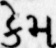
કેમ
